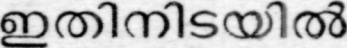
ഇതിനിടയില്‍
